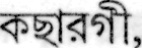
কছারগী,
